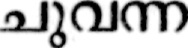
ചുവന്ന
